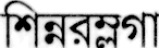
শিন্নরম্লগা
